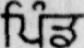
ਪਿੰਡ
